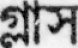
গ্লাস
